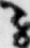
કે
